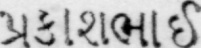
પ્રકાશભાઈ
